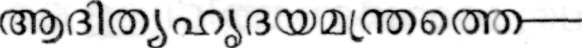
ആദിത്യഹൃദയമന്ത്രത്തെ-
